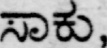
ಸಾಕು,
